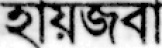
হায়জবা
